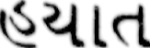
હયાત
